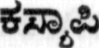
ಕಸ್ಯಾಪಿ
